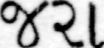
જરા
